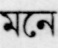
মনে
